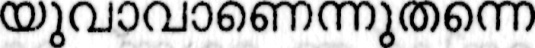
യുവാവാണെന്നുതന്നെ
